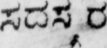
ಸದಸ್ಯರ
